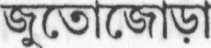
জুতোজোড়া
